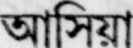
আসিয়া
